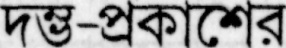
দম্ভ-প্রকাশের
